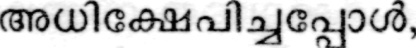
അധിക്ഷേപിച്ചപ്പോള്‍,
